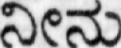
ನೀನು
